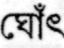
ঘোঁত্
